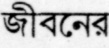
জীবনের
